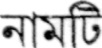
নামটি
